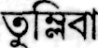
তুম্লিবা
